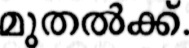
മുതല്‍ക്ക്.
